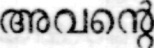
അവന്റെ
